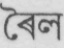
ৰৈল
